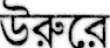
উরুরে
